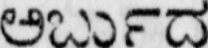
ಅರ್ಬುದ
